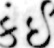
કંઈ
